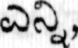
ಎನ್ನಿ,
